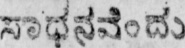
ಸಾಧನವೆಂದು
